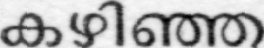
കഴിഞ്ഞ
